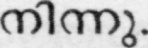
നിന്നു.
